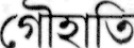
গৌহাতি
